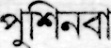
পুশিনবা
